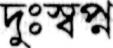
দুঃস্বপ্ন
